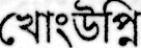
খোংউপ্নি
